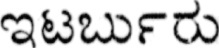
ಇಟರ್ಬುರು
